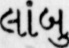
લાંબુ
